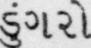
ડુંગરો
